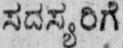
ಸದಸ್ಯರಿಗೆ
